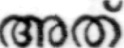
അത്
